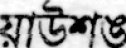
য়াউশঙ
